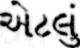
એટલું
